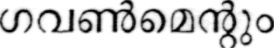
ഗവണ്‍മെന്റും
